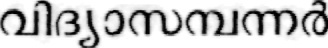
വിദ്യാസമ്പന്നര്‍
